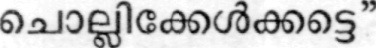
ചൊല്ലിക്കേള്‍ക്കട്ടെ”
